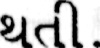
થતી.
